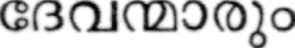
ദേവന്മാരും
